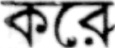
করে
